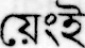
য়েংই
